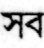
সব
